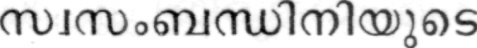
സ്വസംബന്ധിനിയുടെ
